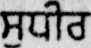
ਸੁਧੀਰ
